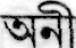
অনী
